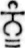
ਨੂੰ
